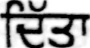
ਦਿੱਤਾ
